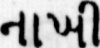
નાખી
